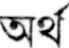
অর্থ
